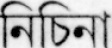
নিচিনা
